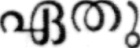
ഏതു
